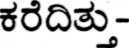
ಕರೆದಿತ್ತು-
